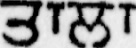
ਤਾਲਾ
